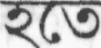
হতে
